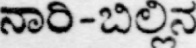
ನಾರಿ-ಬಿಲ್ಲಿನ
